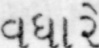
વધારે
